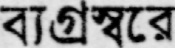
ব্যগ্রস্বরে
